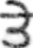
ਤੇ
